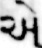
એ
